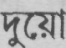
দুয়ো
